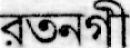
রতনগী
